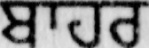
ਬਾਹਰ
